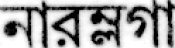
নারম্লগা
